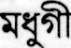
মধুগী
